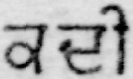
ਕਦੀ
